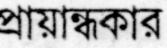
প্রায়ান্ধকার
